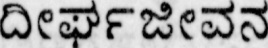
ದೀರ್ಘಜೀವನ
